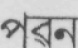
পৱন
